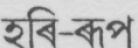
হৰি-ৰূপ
